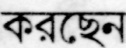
করছেন
